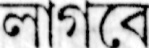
লাগবে
